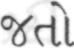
જતો
